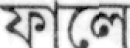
ফালে
